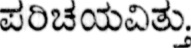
ಪರಿಚಯವಿತ್ತು.
